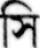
সি
